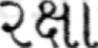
રક્ષા
